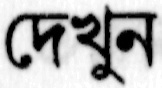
দেখুন
